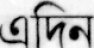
এদিন
